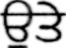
ਉਤੇ
